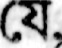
যে,
